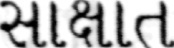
સાક્ષાત
